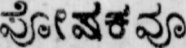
ಪೋಷಕವೂ
